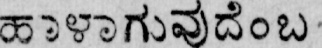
ಹಾಳಾಗುವುದೆಂಬ
